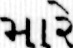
મારે
